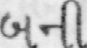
બની
